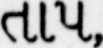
તાપ,
